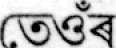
তেওঁৰ
